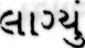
લાગ્યું
